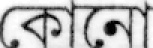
কোনো
